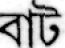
বাট
